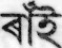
ৰাঁই
